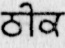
ਠੀਕ
